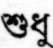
শুধু
